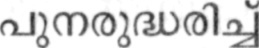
പുനരുദ്ധരിച്ച്
